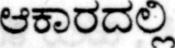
ಆಕಾರದಲ್ಲಿ
